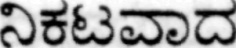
ನಿಕಟವಾದ
